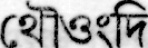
থৌওংদি
